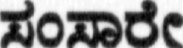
ಸಂಸಾರೇ
